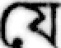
যে
